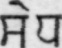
ਸੇਧ
